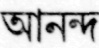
আনন্দ
